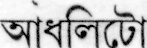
আধলিটো
